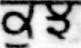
ਕੁਝ
